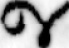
જ
